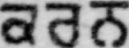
ਕਰਨ
